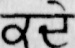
ਕਦੇ
